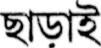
ছাড়াই
